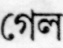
গেল
